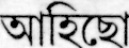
আহিছো
